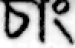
চাং
